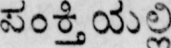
ಪಂಕ್ತಿಯಲ್ಲಿ
